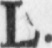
L.
